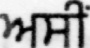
ਅਸੀਂ
